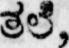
ತಲೆ,
